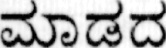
ಮಾಡದ
